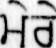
ਮੇਰੇ
